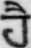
ਹੈ
